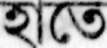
হাতে
